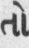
તો
